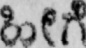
ಹೀಗೆ
